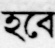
হবে
